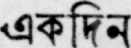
একদিন
